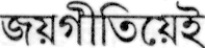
জয়গীতিয়েই
